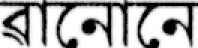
ৱানোনে
